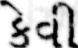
કેવી
